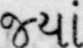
જ્યાં
